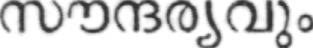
സൌന്ദര്യവും
